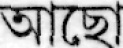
আছো
